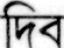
দিব
